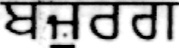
ਬਜ਼ੁਰਗ
